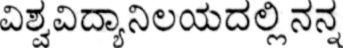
ವಿಶ್ವವಿದ್ಯಾನಿಲಯದಲ್ಲಿನನ್ನ
